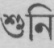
শুনি
